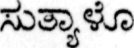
ಸುತ್ಯಾಳೊ
